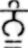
ਨੂੰ
